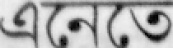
এনেতে
